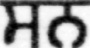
ਸਨ
